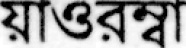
য়াওরম্বা
